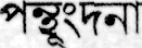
পন্থুংদনা
